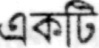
একটি
